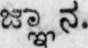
ಜ್ಞಾನ.
